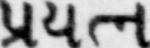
પ્રયત્ન
